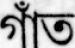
গাঁত
